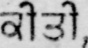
ਕੀਤੀ,
